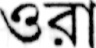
ওরা
